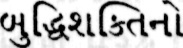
બુદ્ધિશક્તિનો
